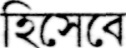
হিসেবে
